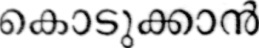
കൊടുക്കാന്‍
